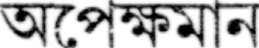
অপেক্ষমান
